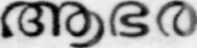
ആഭര
